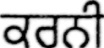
ਕਰਨੀ
